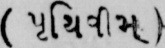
(પૃથિવીમ્)
